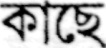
কাছে
